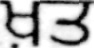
ਖ਼ਤ
